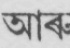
আৰু
